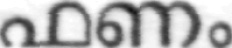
ഫണം
